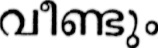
വീണ്ടും
